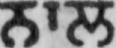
ਨਾਲ
